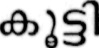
കൂട്ടി
